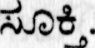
ಸೂಕ್ತಿ.
